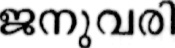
ജനുവരി
